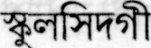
স্কুলসিদগী
